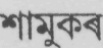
শামুকৰ
